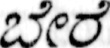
ಬೇರೆ
